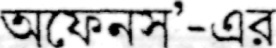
অফেনস’-এর
